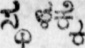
ಸ್ಥಳಕ್ಕೆ
